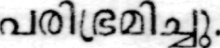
പരിഭ്രമിച്ചു.
